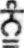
ਨੂੰ
